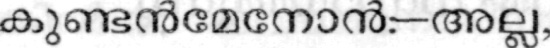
കുണ്ടന്‍മേനോന്‍:-അല്ല,
